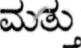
ಮತ್ತು
